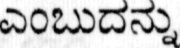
ಎಂಬುದನ್ನು
